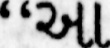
"આ
